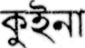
কুইনা
